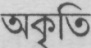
অকৃতি
